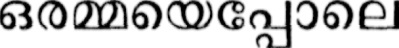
ഒരമ്മയെപ്പോലെ
